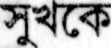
সুখকে
